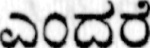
ಎಂದರೆ
